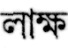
লাক্ষ
